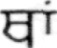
ਥਾਂ
